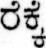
ರೆಕ್ಕೆ
